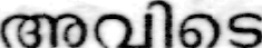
അവിടെ
